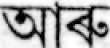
আৰু
